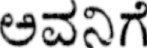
ಅವನಿಗೆ
